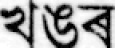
খঙৰ
